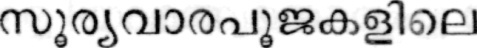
സൂര്യവാരപൂജകളിലെ
